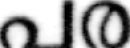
പര
